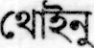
থোইনু
